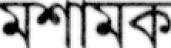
মশামক
